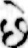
છે
